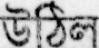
উঠিল
